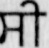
ਸੀ
